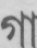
গা
